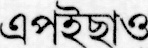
এপইছাও
